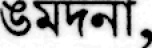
ঙমজনা,
